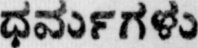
ಧರ್ಮಗಳು
